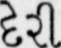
દેરી
